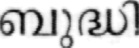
ബുദ്ധി
